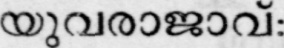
യുവരാജാവ്:
